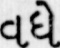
વઘે
